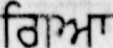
ਗਿਆ
